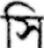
সি
